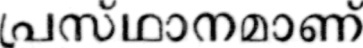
പ്രസ്ഥാനമാണ്
